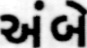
અંબે
